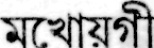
মখোয়গী
